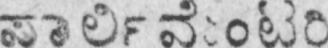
ಪಾರ್ಲಿಮೆಂಟರಿ
